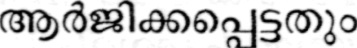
ആര്‍ജിക്കപ്പെട്ടതും
